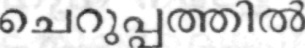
ചെറുപ്പത്തില്‍
